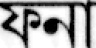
ফনা
